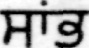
ਸਾਂਭ
